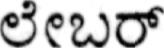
ಲೇಬರ್
